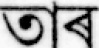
তাৰ
